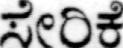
ಸೇರಿಕೆ
